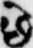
છે
